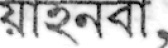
য়াহনবা,
